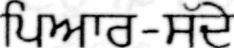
ਪਿਆਰ-ਸੱਦੇ
